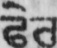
ਫੇਰ
